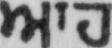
ਆਹ
